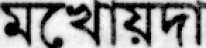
মখোয়দা
